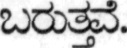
ಬರುತ್ತವೆ.
